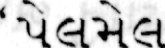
'પેલમેલ
